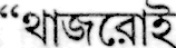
“থাজরোই
